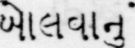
બોલવાનું
